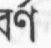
বর্ণ
